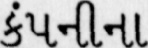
કંપનીના
